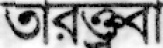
তারক্ত্রবা
